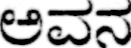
ಅವನ
